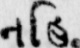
નહિ.
